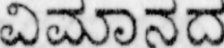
ವಿಮಾನದ
